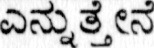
ಎನ್ನುತ್ತೇನೆ
